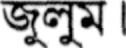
জুলুম।
